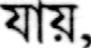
যায়,
